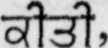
ਕੀਤੀ,
